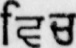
ਵਿਚ
